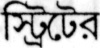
স্ট্রিটের
